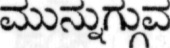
ಮುನ್ನುಗ್ಗುವ
